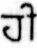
ਹੀ
